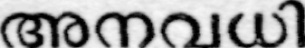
അനവധി
